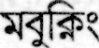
মবুক্নিং
